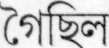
গৈছিল
